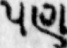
પણ
